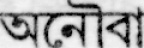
অনৌবা
